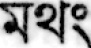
মথং
